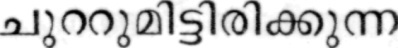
ചുററുമിട്ടിരിക്കുന്ന
